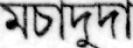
মচাদুদা
